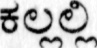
ಕಲ್ಲಲ್ಲಿ
